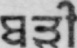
ਬੜੀ
